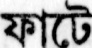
ফাটে
